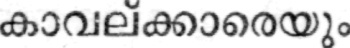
കാവല്ക്കാരെയും
